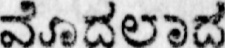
ಮೊದಲಾದ
